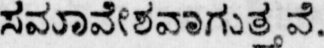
ಸಮಾವೇಶವಾಗುತ್ತವೆ.
